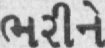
ભરીને
